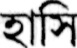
হাসি
